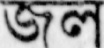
জল
